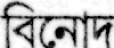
বিনোদ
